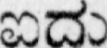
ಐದು
